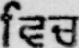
ਵਿਚ
